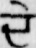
ਦੇ
